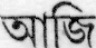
আজি
